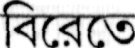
বিরেতে
